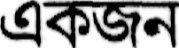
একজন
